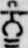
ਨੂੰ
